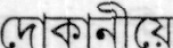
দোকানীয়ে
